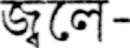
জ্বলে-
